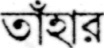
তাঁহার
